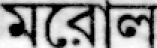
মানা
